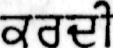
ਕਰਦੀ
